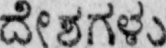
ದೇಶಗಳು
